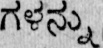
ಗಳನ್ನು
